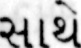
સાથે
